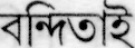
বন্দিতাই
